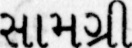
સામગ્રી
